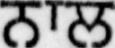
ਨਾਲ
